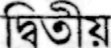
দ্বিতীয়
